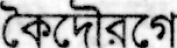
কৈদৌরগে
